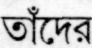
তাঁদের
